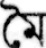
মৈ
